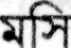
মসি
